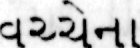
વચ્ચેના
